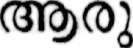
ആരു
